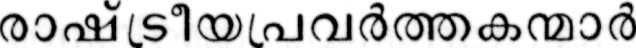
രാഷ്ട്രീയപ്രവര്‍ത്തകന്മാര്‍
